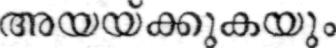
അയയ്ക്കുകയും
